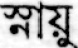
স্নায়ু
